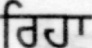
ਰਿਹਾ
